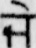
ਜੇ
